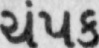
ચંપક
